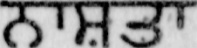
ਨਾਸ਼ਤਾ
